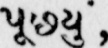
પૂછ્યું,
